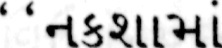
"નકશામાં
